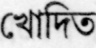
খোদিত
